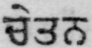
ਚੇਤਨ
